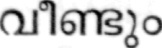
വീണ്ടും
